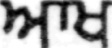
ਆਖ
